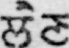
ਲੈਣ
